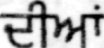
ਦੀਆਂ
